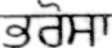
ਭਰੋਸਾ
